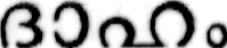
ദാഹം
